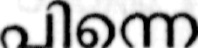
പിന്നെ
